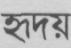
হৃদয়
